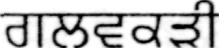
ਗਲਵਕੜੀ
